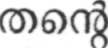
തന്റെ
